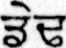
ਡੇਢ
